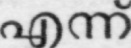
എന്ന്
